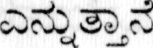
ಎನ್ನುತ್ತಾನೆ
